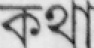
কথা
